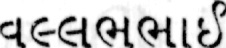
વલ્લભભાઈ
